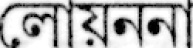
লোয়ননা
